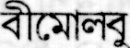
বীমোলবু
